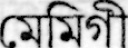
মেমিগী
